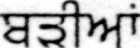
ਬੜੀਆਂ
